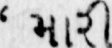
'મારી
